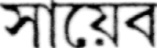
সায়েব
